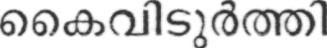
കൈവിടുര്‍ത്തി
